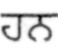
ਹਨ
